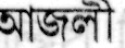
আজলী
